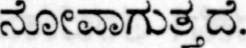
ನೋವಾಗುತ್ತದೆ.
